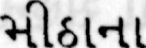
મીઠાના
